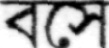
বসে
